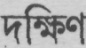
দক্ষিণ
